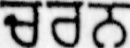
ਚਰਨ
